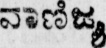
ವಾಣಿಜ್ಯ
